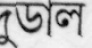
দুডাল
